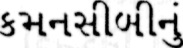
કમનસીબીનું
